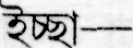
ইচ্ছা-
